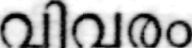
വിവരം
